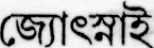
জ্যোৎস্নাই
